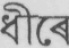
ধীৰে
